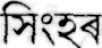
সিংহৰ
